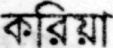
করিয়া
